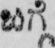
ಬಗ್ಗೆ
